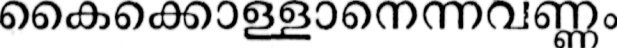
കൈക്കൊള്ളാനെന്നവണ്ണം
